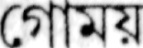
গোময়
